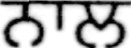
ਨਾਲ
